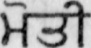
ਮੋਤੀ
